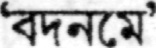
‘বদনমে’
